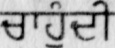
ਚਾਹੁੰਦੀ
